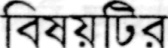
বিষয়টির
